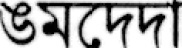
ঙমদেদা
